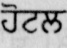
ਹੋਟਲ
